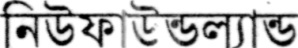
নিউফাউন্ডল্যান্ড
